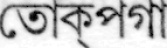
তোক্পগা
